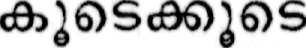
കൂടെക്കൂടെ
